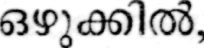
ഒഴുക്കില്‍,
